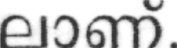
ലാണ്.
